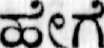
ಹೇಗೆ
